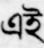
এই
